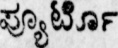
ಪ್ಯೂರ್ಟೊ
